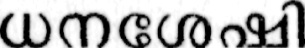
ധനശേഷി
